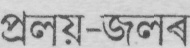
প্ৰলয়-জলৰ
